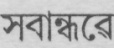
সবান্ধৱে
